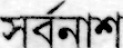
সর্বনাশ
